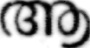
ആ
